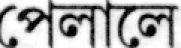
পেলালে
